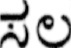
ಸಲ
